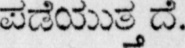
ಪಡೆಯುತ್ತದೆ.
